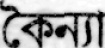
কৈন্যা
